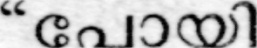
"പോയി
